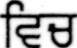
ਵਿਚ
